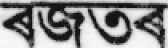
ৰজতৰ
